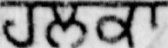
ਹਲਕਾ
